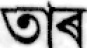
তাৰ
